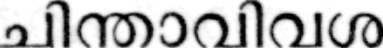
ചിന്താവിവശ
